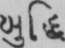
બુદ્ધિ
